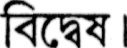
বিদ্বেষ।
